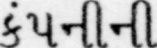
કંપનીની
